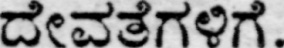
ದೇವತೆಗಳಿಗೆ.
